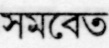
সমবেত
